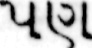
પણ
